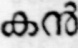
കന്‍
